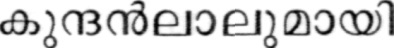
കുന്ദന്‍ലാലുമായി
